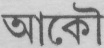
আকৌ
